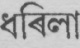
ধৰিলা
